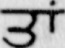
ਤਾਂ
